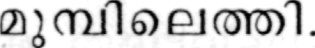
മുമ്പിലെത്തി.
